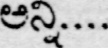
ಅನ್ನಿ.......
